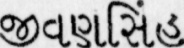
જીવણસિંહ
